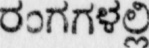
ರಂಗಗಳಲ್ಲಿ
